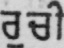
ਰੁਚੀ
